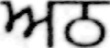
ਅਠ
